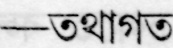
–তথাগত
